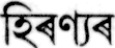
হিৰণ্যৰ
